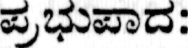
ಪ್ರಭುಪಾದ:
